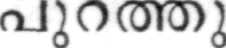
പുറത്തു
